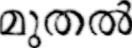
മുതല്‍
